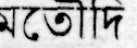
মতৌদি
